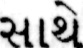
સાથે
